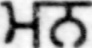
ਮਨ
